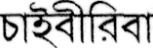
চাইবীরিবা
